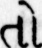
તો
